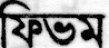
ফিভম
